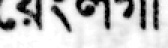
য়েংলগা
